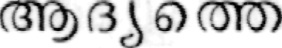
ആദ്യത്തെ
